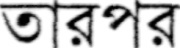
তারপর
